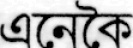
এনেকৈ
